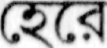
হেরে
